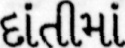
દાંતીમાં
